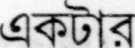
একটার
